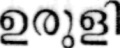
ഉരുളി
